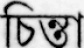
চিন্তা
